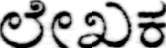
ಲೇಖಕ
